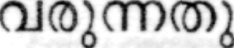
വരുന്നതു
